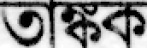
তাঙ্কক
